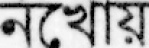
নখোয়
